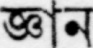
জ্ঞান
